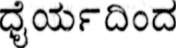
ಧೈರ್ಯದಿಂದ
